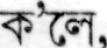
ক'লে,
